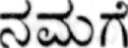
ನಮಗೆ
